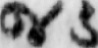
જડ
